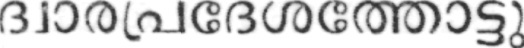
ദ്വാരപ്രദേശത്തോട്ടു
